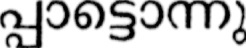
പ്പാട്ടൊന്നു
